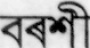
বৰশী
